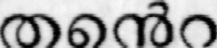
തന്റെ
